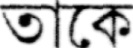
তাকে
